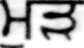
ਮੁੜ
